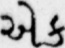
એક
